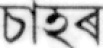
চাহৰ
